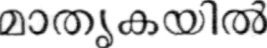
മാതൃകയില്‍
